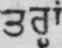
ਤਰ੍ਹਾਂ
